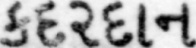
કદરદાન
